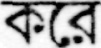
করে
